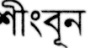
শীংবূন
